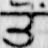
ਤੋਂ
